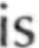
is
